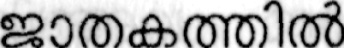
ജാതകത്തില്‍
